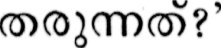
തരുന്നത്?’
